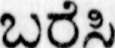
ಬರೆಸಿ
